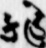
કહે
